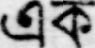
এক
